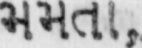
મમતા,
